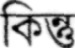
কিন্তু
